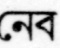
নেব
